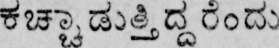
ಕಚ್ಚಾಡುತ್ತಿದ್ದರೆಂದು
